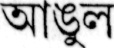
আঙুল
